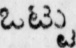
ಒಟ್ಟು
